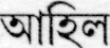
আহিল
